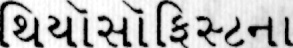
થિયૉસૉફિસ્ટના
